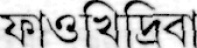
ফাওখিদ্রিবা
